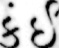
કંઇ
